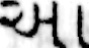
આ
